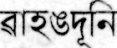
ৱাহঙদূনি
